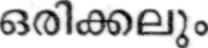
ഒരിക്കലും
